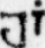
ਹਾਂ
